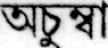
অচুম্বা
